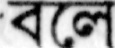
বলে
